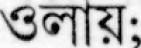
ওলায়;
